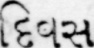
દિવસ
